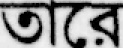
তারে
